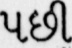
પછી
